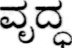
ವೃದ್ಧ
